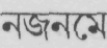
নজনমে
